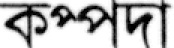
কপ্পদা
